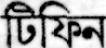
টিফিন
